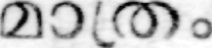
മാത്രം
